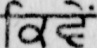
ਕਿਵੇਂ
